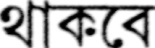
থাকবে
